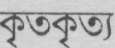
কৃতকৃত্য
